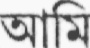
আমি
